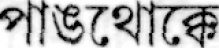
পাঙথোক্কে
